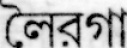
লৈরগা
